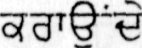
ਕਰਾਉਂਦੇ
